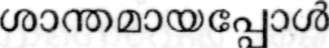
ശാന്തമായപ്പോള്‍
